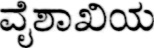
ವೈಶಾಖಿಯ
